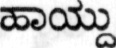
ಹಾಯ್ದು
